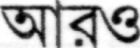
আরও
